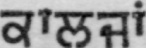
ਕਾਲਜਾਂ
